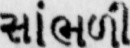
સાંભળી
